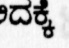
ಅದಕ್ಕೆ
